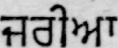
ਜਰੀਆ
